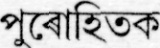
পুৰোহিতক
